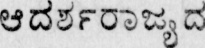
ಆದರ್ಶರಾಜ್ಯದ
